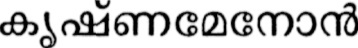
കൃഷ്ണമേനോന്‍
